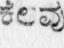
ಕೆಲವು
